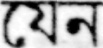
যেন
